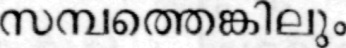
സമ്പത്തെങ്കിലും
